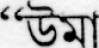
"উমা
